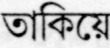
তাকিয়ে
